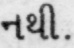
નથી.
